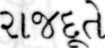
રાજદૂતે
